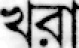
খরা
